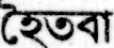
হৈতবা
